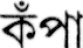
কঁপা
